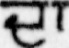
ਦਾ
